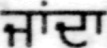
ਜਾਂਦਾ
